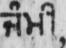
ਜੰਮੀ,
